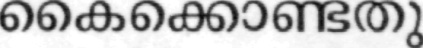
കൈക്കൊണ്ടതു
